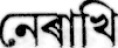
নেৰাখি
